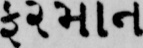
ફરમાન
